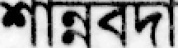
শান্নবদা
